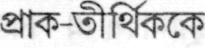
প্রাক-তীর্থিককে
